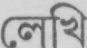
লেখি
